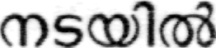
നടയില്‍
